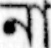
না
